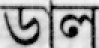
ডাল
